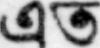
এত
